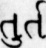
તુર્ત
